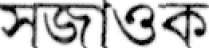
সজাওক
